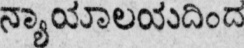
ನ್ಯಾಯಾಲಯದಿಂದ
